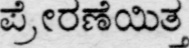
ಪ್ರೇರಣೆಯಿತ್ತ
